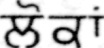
ਲੋਕਾਂ
